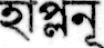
হাপ্লনূ
